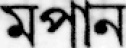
মপান
